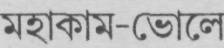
মহাকাম-ভোলে
